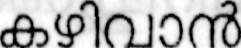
കഴിവാന്‍
